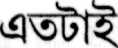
এতটাই
